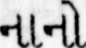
નાનો
